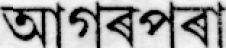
আগৰপৰা
